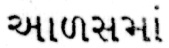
આળસમાં
